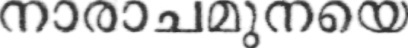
നാരാചമുനയെ
